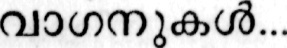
വാഗനുകള്‍...
